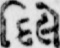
દિલે
